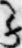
કે
